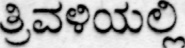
ತ್ರಿವಳಿಯಲ್ಲಿ
